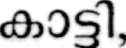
കാട്ടി,
